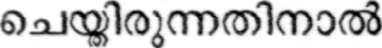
ചെയ്തിരുന്നതിനാല്‍
